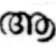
ആ
